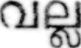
വല്ല
